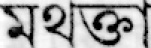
মথক্তা
